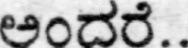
ಅಂದರೆ..
